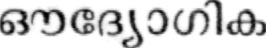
ഔദ്യോഗിക
